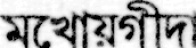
মখোয়গীদা
